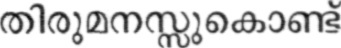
തിരുമനസ്സുകൊണ്ട്
